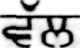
ਵੱਲ
